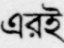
এরই
